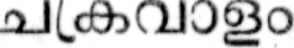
ചക്രവാളം
